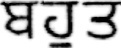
ਬਹੁਤ
